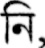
নি,
